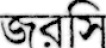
জরসি
